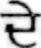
ਦੇ
